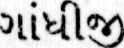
ગાંધીજી
